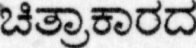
ಚಿತ್ರಾಕಾರದ
